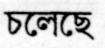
চলেছে
